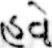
હવે
